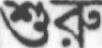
শুরু
